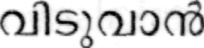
വിടുവാന്‍
